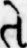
તે
